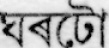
ঘৰটো
